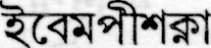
ইবেমপীশক্না
